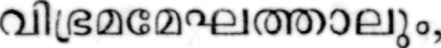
വിഭ്രമമേഘത്താലും,
